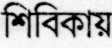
শিবিকায়
